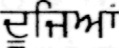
ਦੂਜਿਆਂ
